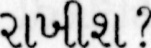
રાખીશ?
